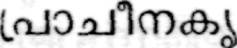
പ്രാചീനകൃ
